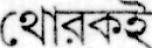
থোরকই
